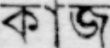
কাজ
